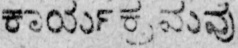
ಕಾರ್ಯಕ್ರಮವು
